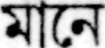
মানে
